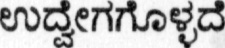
ಉದ್ವೇಗಗೊಳ್ಳದ
